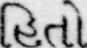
હિતો
